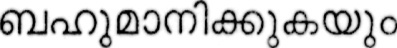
ബഹുമാനിക്കുകയും
